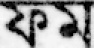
ফম
